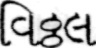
વિઠ્ઠલ
